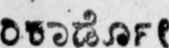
ರಿಕಾರ್ಡೋ
